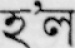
হ'ল
